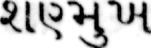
શણ્મુખ
